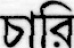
চারি
